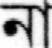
না
